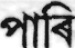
পাৰি
